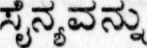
ಸೈನ್ಯವನ್ನು
